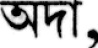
অদা,
